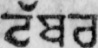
ਟੱਬਰ
